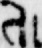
તો
